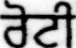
ਰੋਟੀ
